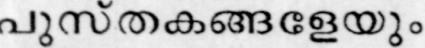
പുസ്തകങ്ങളേയും
